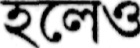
হলেও
